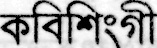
কবিশিংগী
